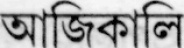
আজিকালি
